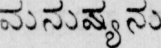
ಮನುಷ್ಯನು
